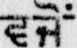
ਵਜੋਂ
